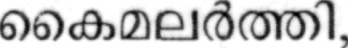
കൈമലര്‍ത്തി,
